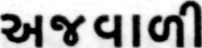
અજવાળી
